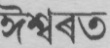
ঈশ্বৰত
